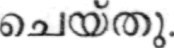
ചെയ്തു.
